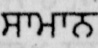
ਸਾਮਾਨ
